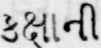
કક્ષાની
